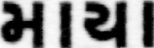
માયા
